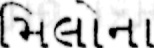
મિલોના
